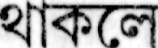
থাকলে
